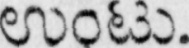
ಉಂಟು.
